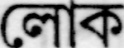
লোক
